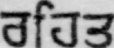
ਰਹਿਤ
